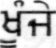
ਖੂੰਜੇ
